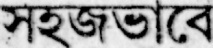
সহজভাবে
